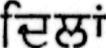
ਦਿਲਾਂ
